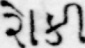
રોકી
